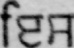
ਇਸ
